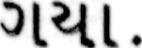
ગયા.
